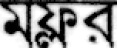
মফ্লর
